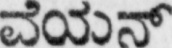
ವೆಯನ್
